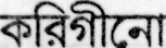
করিগীনো
